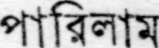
পারিলাম
